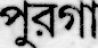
পুরগা
